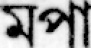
মপা
